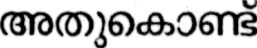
അതുകൊണ്ട്
